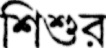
শিশুর
